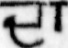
ਦਾ
